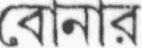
বোনার
